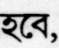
হবে,
